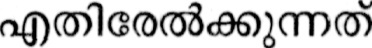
എതിരേല്‍ക്കുന്നത്
